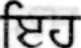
ਇਹ
